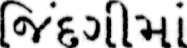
જિંદગીમાં
